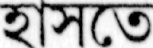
হাসতে
